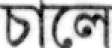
চালে
